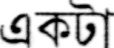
একটা
